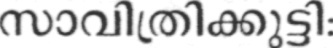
സാവിത്രിക്കുട്ടി:
